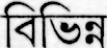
বিভিন্ন
